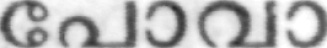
പോവാ
